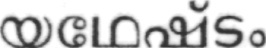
യഥേഷ്ടം
